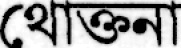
থোক্তনা
